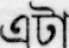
এটা
